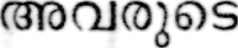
അവരുടെ
